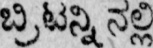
ಬ್ರಿಟನ್ನಿನಲ್ಲಿ
